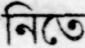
নিতে
